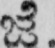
ಜೆ.
